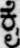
ಕೈ
